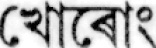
খোৰোং
